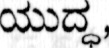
ಯುದ್ಧ,
